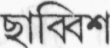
ছাব্বিশ
